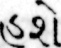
હશે
